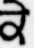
ਕੇ
